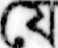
যে
